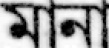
মানা
